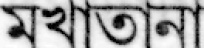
মখাতানা
